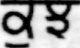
ਕੁਝ
